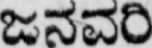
ಜನವರಿ
